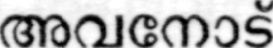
അവനോട്
